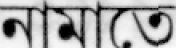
নামাতে
